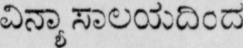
ವಿನ್ಯಾಸಾಲಯದಿಂದ
